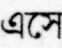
এসে
